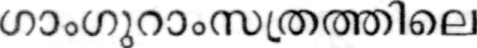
ഗാംഗുറാംസത്രത്തിലെ
